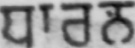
ਧਾਰਨ
